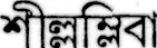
শীল্লম্লিবা
